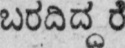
ಬರದಿದ್ದರೆ
